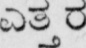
ಎತ್ತರ
